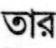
তার
